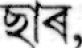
ছাৰ,
